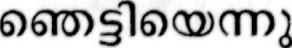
ഞെട്ടിയെന്നു
